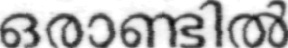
ഒരാണ്ടില്‍
